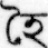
হৈ
